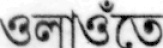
ওলাওঁতে
